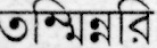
তম্মিন্নরি
